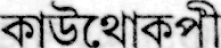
কাউথোকপী
